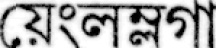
য়েংলম্লগা
